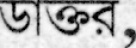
ডাক্তর,
